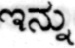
ಇನ್ನು
